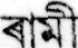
ৰামী
